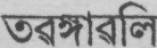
তৱঙ্গাৱলি
